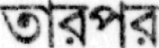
তারপর
